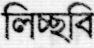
লিচ্ছবি
